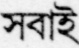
সবাই
